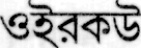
ওইরকউ
